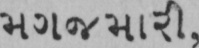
મગજમારી,
